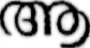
ആ
